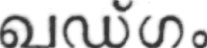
ഖഡ്ഗം
